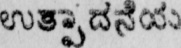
ಉತ್ಪಾದನೆಯ
